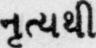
નૃત્યથી
